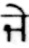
ਜੇ
